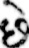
છે
